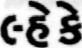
લ્હેકે
